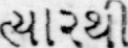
ત્યારથી
